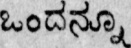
ಒಂದನ್ನೂ
